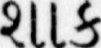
શાક
